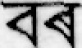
বৰ
